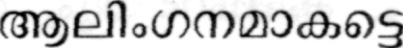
ആലിംഗനമാകട്ടെ
